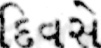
દિવસે
